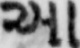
આ
